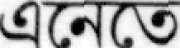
এনেতে
